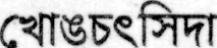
খোঙচৎসিদা
